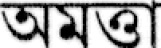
অমত্তা
